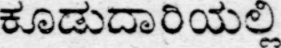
ಕೂಡುದಾರಿಯಲ್ಲಿ
